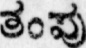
ತಂಪು
